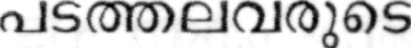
പടത്തലവരുടെ
